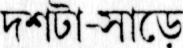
দশটা-সাড়ে
